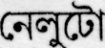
নেলুটো
